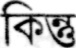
কিন্তু
